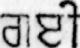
ਗਈ
